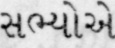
સભ્યોએ
